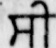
ਸੀ
